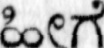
ಹೀಗೆ
